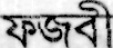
ফজবী
